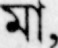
মা,
